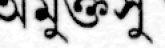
অমুক্তসু
